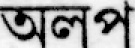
অলপ
